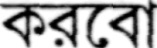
করবো
